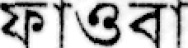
ফাওবা
